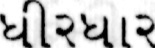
ધીરધાર
